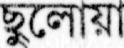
ছুলোয়া
